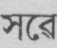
সৱে
